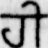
ਹੀ
